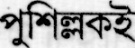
পুশিল্লকই
